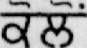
ਕੋਲੋਂ
